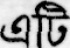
এটি
